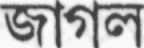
জাগল
